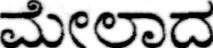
ಮೇಲಾದ
